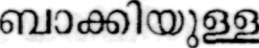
ബാക്കിയുള്ള
